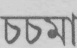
চচমা
